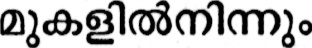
മുകളില്‍നിന്നും
